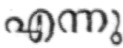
എന്നു
